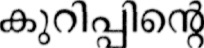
കുറിപ്പിന്റെ
